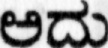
ಅದು
